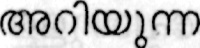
അറിയുന്ന
